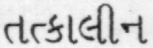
તત્કાલીન
